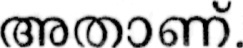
അതാണ്.
